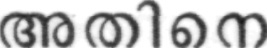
അതിനെ
